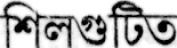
শিলগুটিত
